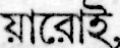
য়ারোই,
